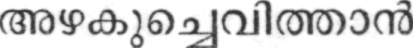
അഴകുച്ചെവിത്താന്‍
